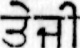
ਤੇਜੀ
